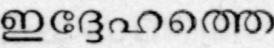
ഇദ്ദേഹത്തെ
